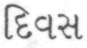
દિવસ
